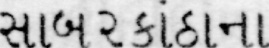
સાબરકાંઠાના
